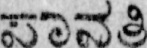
ಪಾವತಿ
